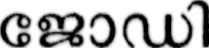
ജോഡി
